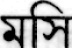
মসি
